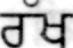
ਰੱਖ
